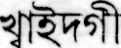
খ্বাইদগী
